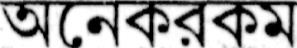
অনেকরকম
